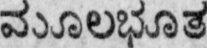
ಮೂಲಭೂತ
